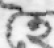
হৈ
